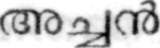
അച്ചന്‍
